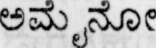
ಅಮೈನೋ
